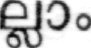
ല്ലാം
